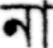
না
